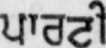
ਪਾਰਟੀ
